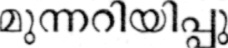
മുന്നറിയിപ്പു
